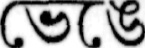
ভেঙে
